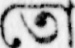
তো
